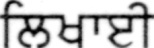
ਲਿਖਾਈ
